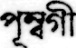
পূম্বগী
